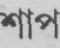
শাপ
